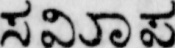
ಸಮೀಪ
